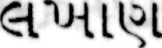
લખાણ
